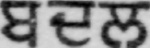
ਬਦਲ
